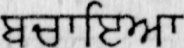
ਬਚਾਇਆ
